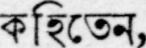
কহিতেন,
